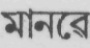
মানৱে
